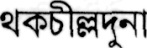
থকচীল্লদুনা
